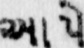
આપે
